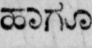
ಹಾಗೂ
